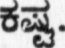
ಕಷ್ಟ.
